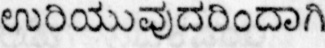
ಉರಿಯುವುದರಿಂದಾಗಿ
